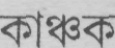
কাঞ্চক
